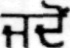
ਜਦੋਂ
